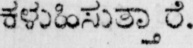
ಕಳುಹಿಸುತ್ತಾರೆ.
